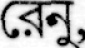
রেনু,
